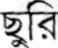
ছুরি
